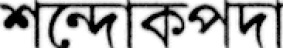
শন্দোকপদা
